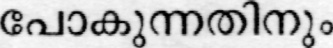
പോകുന്നതിനും
